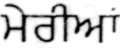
ਮੇਰੀਆਂ
